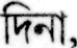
দিনা,
